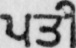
ਪਤੀ
